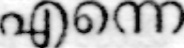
എന്നെ
